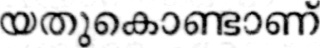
യതുകൊണ്ടാണ്
